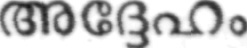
അദ്ദേഹം
